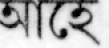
আহে
